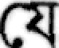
যে
